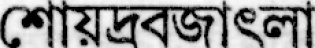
শোয়দ্রবজাৎলা
